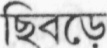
ছিবড়ে
